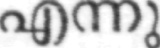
എന്നു
